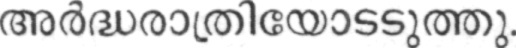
അര്‍ദ്ധരാത്രിയോടടുത്തു.
